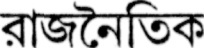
রাজনৈতিক
